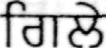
ਗਿਲੇ
